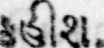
કહીશ.
